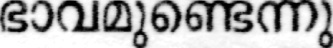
ഭാവമുണ്ടെന്നു
